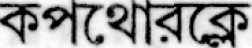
কপথোরক্লে
